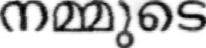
നമ്മുടെ
